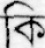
কি
